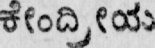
ಕೇಂದ್ರೀಯ
